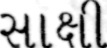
સાક્ષી
